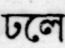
ঢলে
